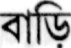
বাড়ি
